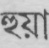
হুয়া
